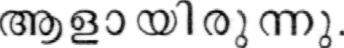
ആളായിരുന്നു.
